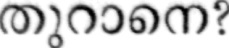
തുറാനെ?
